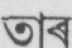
তাৰ
